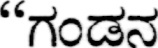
"ಗಂಡನ
